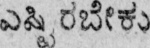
ಎಷ್ಟಿರಬೇಕು
